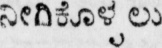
ನೀಗಿಕೊಳ್ಳಲು
